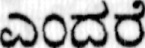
ಎಂದರೆ
